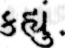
કહ્યું.
